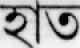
হাত
